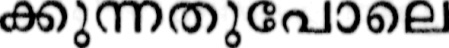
ക്കുന്നതുപോലെ
